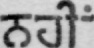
ਨਹੀਂ
